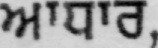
ਆਧਾਰ,
